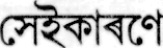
সেইকাৰণে
